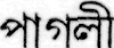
পাগলী
